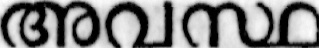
അവസ്ഥ
